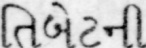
તિબેટની
